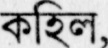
কহিল,
